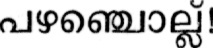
പഴഞ്ചൊല്ല്!
